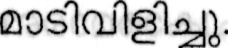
മാടിവിളിച്ചു.
